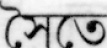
সৈতে
